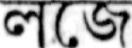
লজে
